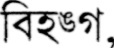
বিহঙ্গ,
